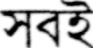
সবই
